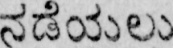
ನಡೆಯಲು
